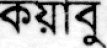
কয়াবু
